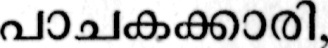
പാചകക്കാരി,
